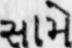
સામે
